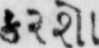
કરશો
